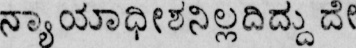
ನ್ಯಾಯಾಧೀಶನಿಲ್ಲದಿದ್ದುದೇ
